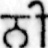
ਨੀ
